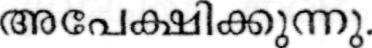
അപേക്ഷിക്കുന്നു.
